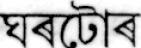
ঘৰটোৰ
